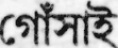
গোঁসাই
